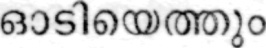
ഓടിയെത്തും
